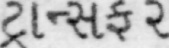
ટ્રાન્સફર
